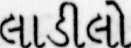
લાડીલો
